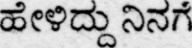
ಹೇಳಿದ್ದುನಿನಗೆ
